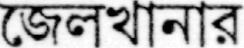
জেলখানার
